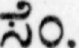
ಸೆಂ.
